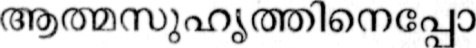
ആത്മസുഹൃത്തിനെപ്പോ
